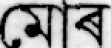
মোৰ
